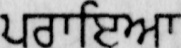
ਪਰਾਇਆ
